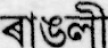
ৰাঙলী
